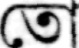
তো
